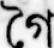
গৈ
